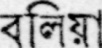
বলিয়া
